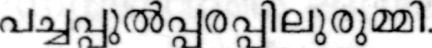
പച്ചപ്പുല്‍പ്പരപ്പിലുരുമ്മി.
